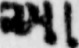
આ
